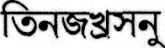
তিনজখ্রসনু
